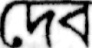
দেব
